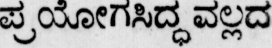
ಪ್ರಯೋಗಸಿದ್ಧವಲ್ಲದ
